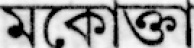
মকোক্তা
